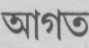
আগত
